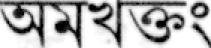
অমখক্তং
